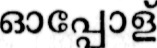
ഓപ്പോള്
